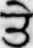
ਤੇ
